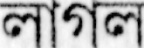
লাগল
